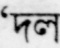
‘দল
